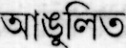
আঙুলিত
